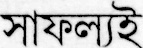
সাফল্যই
